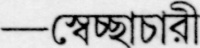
–স্বেচ্ছাচারী
